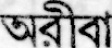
অরীবা
